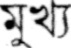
মুখ্য
